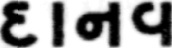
દાનવ
